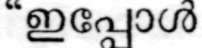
“ഇപ്പോള്‍
